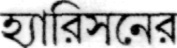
হ্যারিসনের
